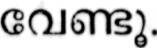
വേണ്ടൂ.
